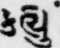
કહ્યું
